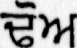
ਢੋਅ
